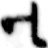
ન
